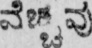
ವೆಚ್ಚವು
